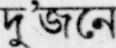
দু'জনে
